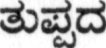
ತುಪ್ಪದ
